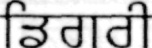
ਡਿਗਰੀ
